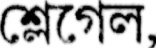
শ্লেগেল,
